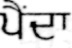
ਪੈਂਦਾ
